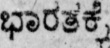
ಭಾರತಕ್ಕೆ
